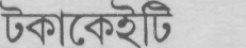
টকাকেইটি
